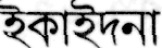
ইকাইদনা
